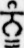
ਨੂੰ
